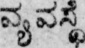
ವ್ಯವಸ್ಥೆ
